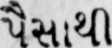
પૈસાથી
